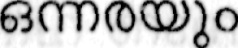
ഒന്നരയും
